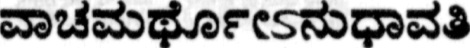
ವಾಚಮರ್ಥsನುಧಾವತಸಿ
